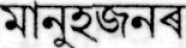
মানুহজনৰ
